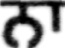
ਨਾ
